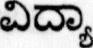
ವಿದ್ಯಾ
